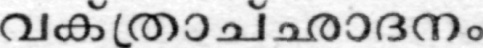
വക്ത്രാച്ഛാദനം
